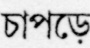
চাপড়ে
